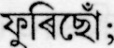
ফুৰিছোঁ;
